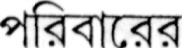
পরিবারের
